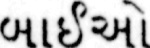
બાઈઓ
